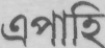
এপাহি
